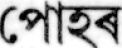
পোহৰ
